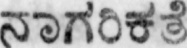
ನಾಗರಿಕತೆ
